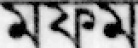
মফম
